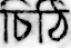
চিঠি
